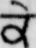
ਕੇ
